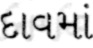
દાવમાં
